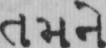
તમને
